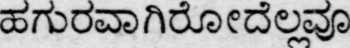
ಹಗುರವಾಗಿರೋದೆಲ್ಲವೂ
